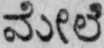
ಮೇಲೆ
